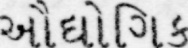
ઔધોગિક
